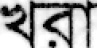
খরা
